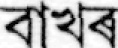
বাখৰ
